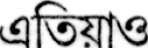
এতিয়াও
